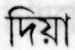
দিয়া
